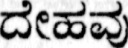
ದೇಹವು
